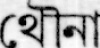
থৌনা
